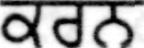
ਕਰਨ
